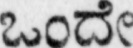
ಒಂದೇ
